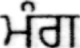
ਮੰਗ
